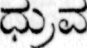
ಧ್ರುವ
